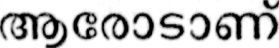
ആരോടാണ്
